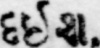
દઈશ.
